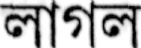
লাগল
